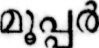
മൂപ്പര്‍
